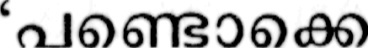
‘പണ്ടൊക്കെ
